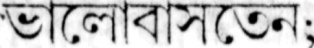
ভালোবাসতেন;
